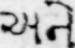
અને
